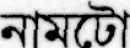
নামটো
